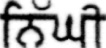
ਨਿੱਘੀ
